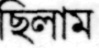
ছিলাম
